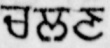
ਚਲਣ
